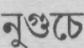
নুগুচে
